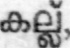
കല്ല്,
